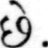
છે.
